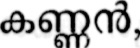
കണ്ണന്‍,
